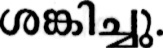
ശങ്കിച്ചു.
